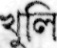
খুলি
